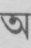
অ
